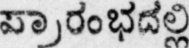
ಪ್ರಾರಂಭದಲ್ಲಿ
